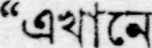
‘‘এখানে
